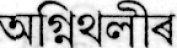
অগ্নিথলীৰ
